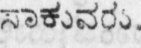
ಸಾಕುವರು.
